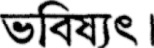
ভবিষ্যৎ।
